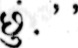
છું."
